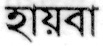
হায়বা
